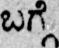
ಬಗ್ಗೆ
